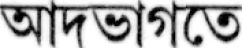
আদভাগতে
